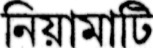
নিয়ামাটি
